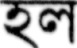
হল
